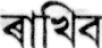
ৰাখিব
